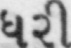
ધરી
